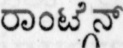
ರಾಂಟ್ಗೆನ್
